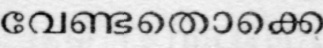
വേണ്ടതൊക്കെ
